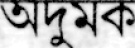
অদুমক
